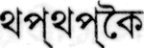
থপ্‌থপকৈ
